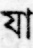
যা
